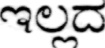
ಇಲ್ಲದ
